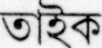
তাইক
